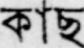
কাছ
